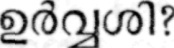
ഉര്‍വ്വശി?
